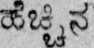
ಹೆಚ್ಚಿನ
